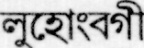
লুহোংবগী
